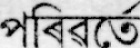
পৰিৱর্তে
